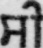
ਸੀ
